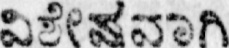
ವಿಶೇಷವಾಗಿ
